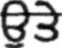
ਉਤੇ
